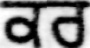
ਕਰ
